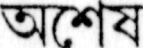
অশেষ
